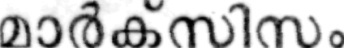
മാര്‍ക്സിസം
